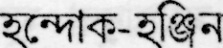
হন্দোক-হঞ্জিন
